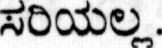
ಸರಿಯಲ್ಲ.
